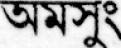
অমসুং
